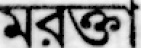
মরক্তা
